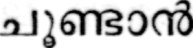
ചൂണ്ടാന്‍
